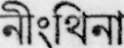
নীংথিনা
